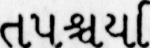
તપશ્ચર્યા
